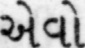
એવો
